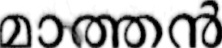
മാത്തന്‍
